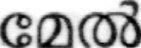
മേല്‍
